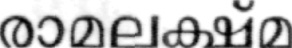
രാമലക്ഷ്മ
